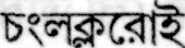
চংলক্লরোই
